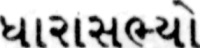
ધારાસભ્યો
